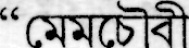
“মেমচৌবী
